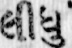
લીધું
